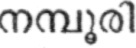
നമ്പൂരി
